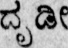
ದೃಡೀ
